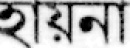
হায়না
